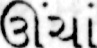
ઊંચાં
